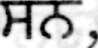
ਸਨ,
